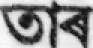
তাৰ
